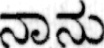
ನಾನು
